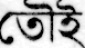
তৌই
